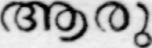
ആരു
